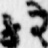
કરે
